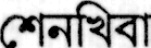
শেনখিবা
